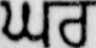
ਘਰ
